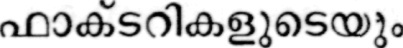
ഫാക്ടറികളുടെയും
